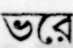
ভরে
